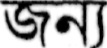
জন্য
